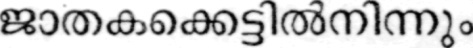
ജാതകക്കെട്ടില്‍നിന്നും
